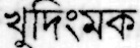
খুদিংমক
